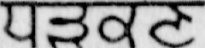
ਧੜਕਣ
